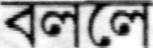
বললে
